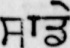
ਸਾਡੇ
